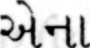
એના
